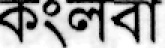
কংলবা
